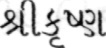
શ્રીકૃષ્ણ
